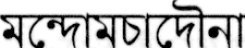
মন্দোমচাদৌনা
